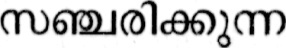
സഞ്ചരിക്കുന്ന
